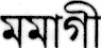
মমাগী
